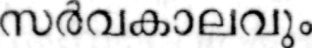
സര്‍വകാലവും
